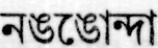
নঙঙোন্দা
